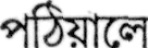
পঠিয়ালে
